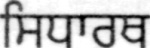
ਸਿਧਾਰਥ
